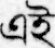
এই
